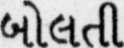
બોલતી
